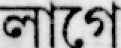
লাগে
